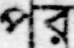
পর
